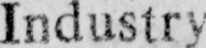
Industry
